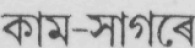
কাম-সাগৰে
